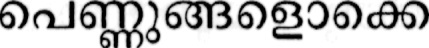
പെണ്ണുങ്ങളൊക്കെ
